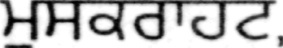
ਮੁਸਕਰਾਹਟ,
